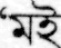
'মই
